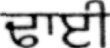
ਢਾਈ
